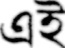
এই
